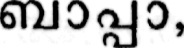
ബാപ്പാ,
